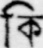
কি
